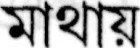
মাথায়
